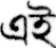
এই
